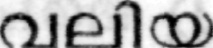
വലിയ
